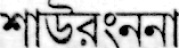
শাউরংননা
